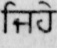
ਜਿਹੇ
